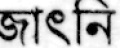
জাৎনি
